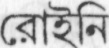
রোইনি
